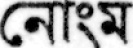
নোংম
